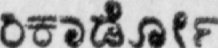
ರಿಕಾರ್ಡೋ
